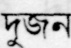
দুজন
